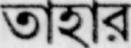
তাহার
